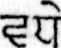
ਵਧੇ
